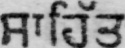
ਸਾਹਿੱਤ
